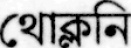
থোক্লনি
